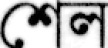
শেল
